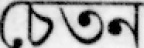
চেতন
